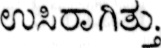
ಉಸಿರಾಗಿತ್ತು.
